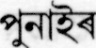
পুনাইৰ
